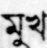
মুখ
